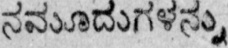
ನಮೂದುಗಳನ್ನು
